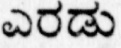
ಎರಡು
